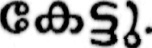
കേട്ടു.
